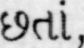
છતાં,
